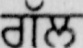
ਗੱਲ
